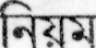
নিয়ম
